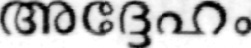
അദ്ദേഹം
